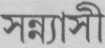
সন্ন্যাসী
